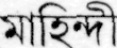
মাহিন্দী
